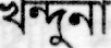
খন্দুনা
